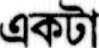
একটা
